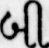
બી
